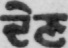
ਦੇਣ
